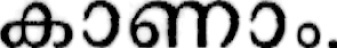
കാണാം.
